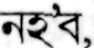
নহ'ব,
